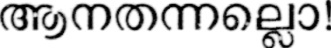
ആനതന്നല്ലൊ!
